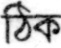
ঠিক
